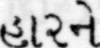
હારને
